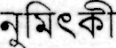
নুমিৎকী
